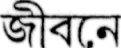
জীবনে
